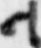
ન
